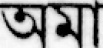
অমা
